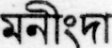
মনীংদা
